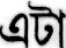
এটা
